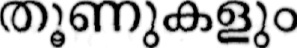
തൂണുകളും
